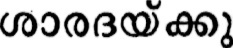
ശാരദയ്ക്കു
